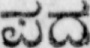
ಪದ
